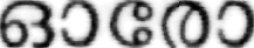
ഓരോ
